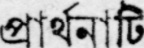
প্রার্থনাটি
